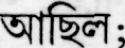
আছিল;
